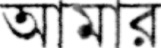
আমার
